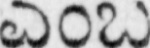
ಎಂಬ
